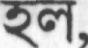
হল,
